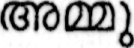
അമ്മു
